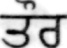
ਤੌਰ
